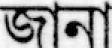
জানা
